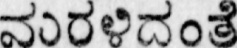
ಮರಳಿದಂತೆ
